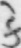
કે
